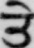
ਤੇ
